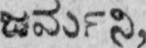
ಜರ್ಮನಿ,
